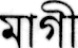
মাগী
